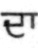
ਦਾ
